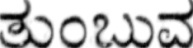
ತುಂಬುವ
